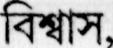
বিশ্বাস,
